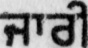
ਜਾਰੀ
